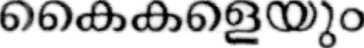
കൈകളെയും
